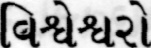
વિશ્વેશ્વરો
